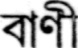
বাণী
